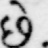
છે.
